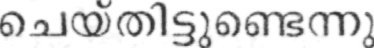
ചെയ്തിട്ടുണ്ടെന്നു
